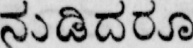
ನುಡಿದರೂ
